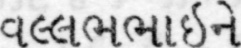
વલ્લભભાઈને
